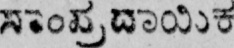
ಸಾಂಪ್ರದಾಯಿಕ
